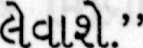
લેવાશે."
